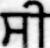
ਸੀ
